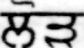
ਲੋੜ
